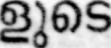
ളുടെ
